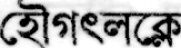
হৌগৎলক্লে
